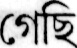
গেছি
